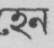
হেন
